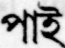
পাই
